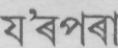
য'ৰপৰা
